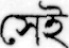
সেই
